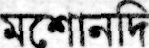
মশোনদি
